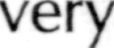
very
